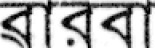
ৱারবা
